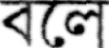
বলে
